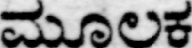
ಮೂಲಕ
